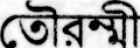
তৌরম্মী
